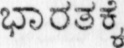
ಭಾರತಕ್ಕೆ
